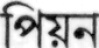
পিয়ন
